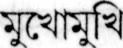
মুখোমুখি
